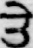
ਤੇ
